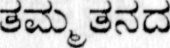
ತಮ್ಮತನದ
